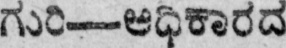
ಗುರಿ-ಅಧಿಕಾರದ
